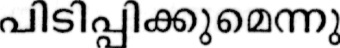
പിടിപ്പിക്കുമെന്നു
